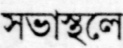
সভাস্থলে
